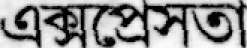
এক্সপ্রেসতা
